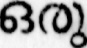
ഒരു
